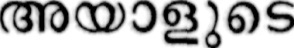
അയാളുടെ
